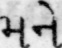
મને
